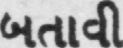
બતાવી
